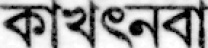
কাখৎনবা
